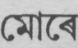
মোৰে
